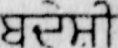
ਬਦੇਸ਼ੀ
